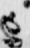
હું
